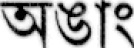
অঙাং
